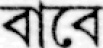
বাবে
